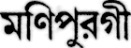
মণিপুরগী
